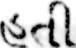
હતી
